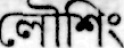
লৌশিং
